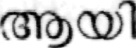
ആയി
